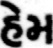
હેમ
